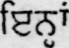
ਇਨ੍ਹਾਂ
